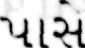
પાસે
